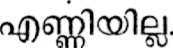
എണ്ണിയില്ല.
